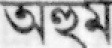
অহুম
